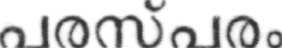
പരസ്പരം
